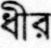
ধীর
